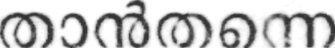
താന്‍തന്നെ
